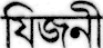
যিজনী
